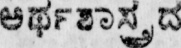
ಅರ್ಥಶಾಸ್ತ್ರದ
